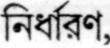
নির্ধারণ,
